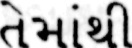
તેમાંથી
